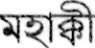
মহাক্কী
